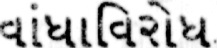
વાંધાવિરોધ
